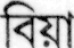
বিয়া
